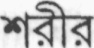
শরীর
